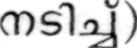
നടിച്ച്)
